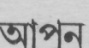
আপন
